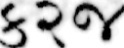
કરજ
